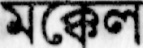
মক্কেল
